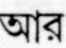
আর
